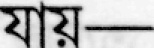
যায়-
